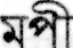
মপী
